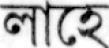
লাহে
